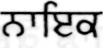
ਨਾਇਕ
